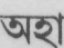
অহা
